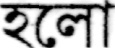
হলো
